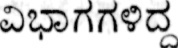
ವಿಭಾಗಗಳಿದ್ದ
